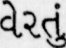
વેરતું
